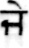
ਜੇ
